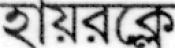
হায়রক্লে
